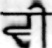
ਵੀ
